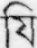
যি
